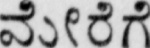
ಮೇರೆಗೆ
